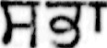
ਸਭਾ
